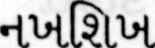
નખશિખ
